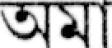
অমা
